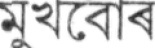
মুখবোৰ
